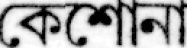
কেশোনা
